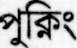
পুক্নিং
